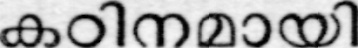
കഠിനമായി
